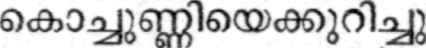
കൊച്ചുണ്ണിയെക്കുറിച്ചു
